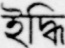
ইদ্ধি
